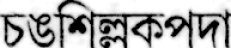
চঙশিল্লকপদা
